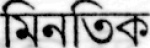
মিনতিক
